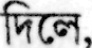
দিলে,
